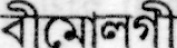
বীমোলগী
